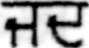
ਜਦ
